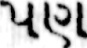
પણ
